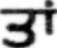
ਤਾਂ
